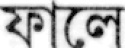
ফালে
